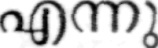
എന്നു
